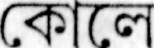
কোলে
